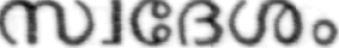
സ്വദേശം
